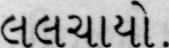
લલચાયો.
